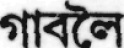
গাবলৈ
